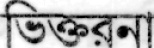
ভিক্তরনা
